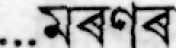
...মৰণৰ
